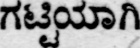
ಗಟ್ಟಿಯಾಗಿ
